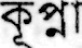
কূপ্ন
